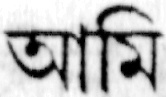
আমি
